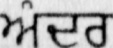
ਅੰਦਰ
